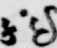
માટે
